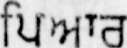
ਪਿਆਰ
